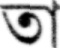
তা
